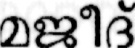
മജീദ്
